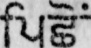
ਪਿਛੋਂ
